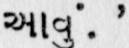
આવું.'
